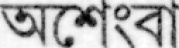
অশেংবা
